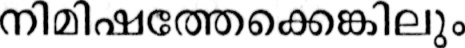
നിമിഷത്തേക്കെങ്കിലും
